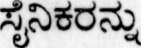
ಸೈನಿಕರನ್ನು
